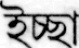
ইচ্ছা
